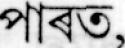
পাৰত,
